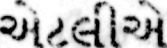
એટલીએ
